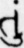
તું
